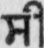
ਸੀ
